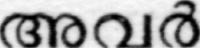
അവര്‍
